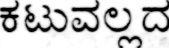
ಕಟುವಲ್ಲದ
